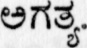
ಅಗತ್ಯ.
